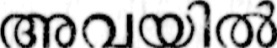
അവയില്‍
